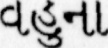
વહુના
